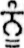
ਨੂੰ
